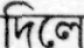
দিলে
